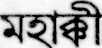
মহাক্কী
